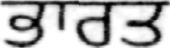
ਭਾਰਤ
